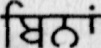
ਬਿਨਾਂ
